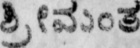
ಶ್ರೀಮಂತ
